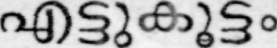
എട്ടുകൂട്ടം
